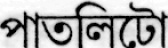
পাতলিটো
